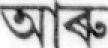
আৰু
